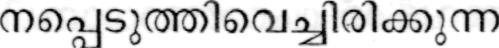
നപ്പെടുത്തിവെച്ചിരിക്കുന്ന
